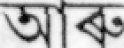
আৰু
